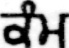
ਕੰਮ
